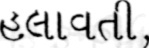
હલાવતી,
